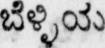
ಬೆಳ್ಳಿಯ
